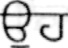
ਉਹ
